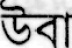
উবা
